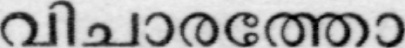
വിചാരത്തോ
